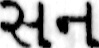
સન
